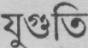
যুগুতি
